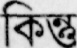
কিন্তু
